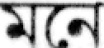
মনে
